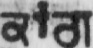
ਕਾਂਗ
